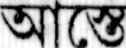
আস্তে
